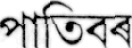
পাতিবৰ
